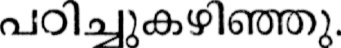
പഠിച്ചുകഴിഞ്ഞു.
